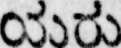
ಯರು
